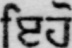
ਇਹੋ
